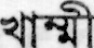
খাম্মী
